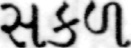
સકળ
